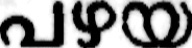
പഴയ
